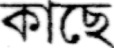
কাছে
